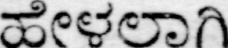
ಹೇಳಲಾಗಿ
